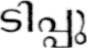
ടിപ്പു
